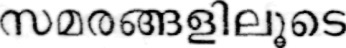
സമരങ്ങളിലൂടെ
